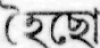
হৈছো
